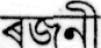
ৰজনী
